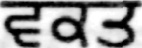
ਵਕਤ
